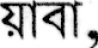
য়াবা,
